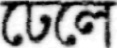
ঢেলে
